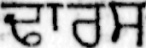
ਢਾਰਸ
